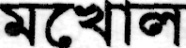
মখোল
